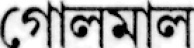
গোলমাল
